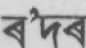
ৰ'দৰ
